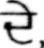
ਦੇ,
